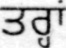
ਤਰ੍ਹਾਂ
